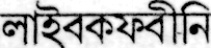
লাইবকফবীনি
